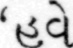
'હવે
